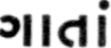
ગાતાં
